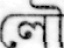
লৌ
